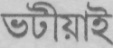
ভটীয়াই
